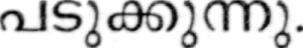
പടുക്കുന്നു.
